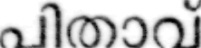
പിതാവ്
